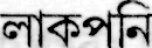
লাকপনি
